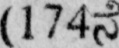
(174ನೆ
